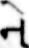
ને
